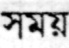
সময়
